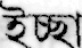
ইচ্ছা
